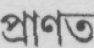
প্ৰাণত
